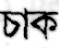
চাক
